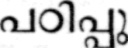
പഠിപ്പു
